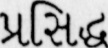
પ્રસિદ્ધ
